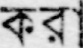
করা
